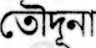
তৌদূনা
